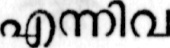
എന്നിവ
